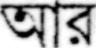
আর
